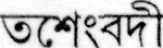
তশেংবদী
